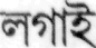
লগাই
